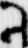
ને
